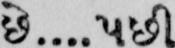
છે....પછી
